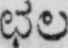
ಛಲ
